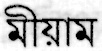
মীয়াম
